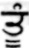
ਤੂੰ
